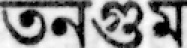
তনগুম
